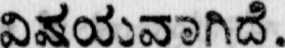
ವಿಷಯವಾಗಿದೆ.
